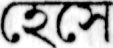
হেসে
